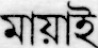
মায়াই
